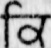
ਕਿ
